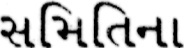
સમિતિના
